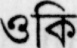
ওকি
